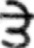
ਤੇ
